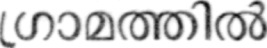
ഗ്രാമത്തില്‍
